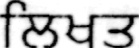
ਲਿਖਤ
